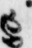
હું
